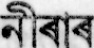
নীৰাৰ
